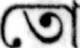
তো
